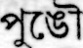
পুঙৌ,
